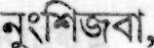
নুংশিজবা,
